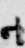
ન
